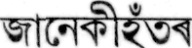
জানেকীহঁতৰ
